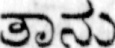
ತಾನು
